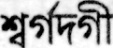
শ্বর্গদগী
